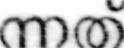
ന്നത്
